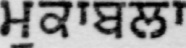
ਮੁਕਾਬਲਾ
